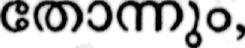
തോന്നും,
